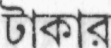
টাকার
